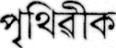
পৃথিৱীক
